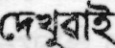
দেখুৱাই
